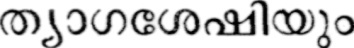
ത്യാഗശേഷിയും
